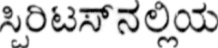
ಸ್ಪಿರಿಟಸ್ನಲ್ಲಿಯ
